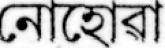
নোহোৱা
